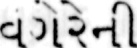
વગેરેની
